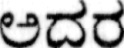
ಅದರ
